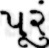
પૂરું
